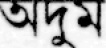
অদুম
